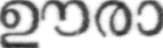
ഊരാ
